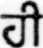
ਹੀ
